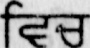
ਵਿਚ
